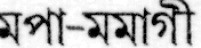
মপা-মমাগী
